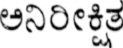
ಅನಿರೀಕ್ಷಿತ
